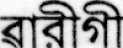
ৱারীগী
